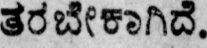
ತರಬೇಕಾಗಿದೆ.
